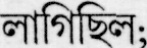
লাগিছিল;
